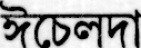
ঈচেলদা
